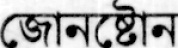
জোনষ্টোন
